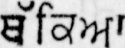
ਥੱਕਿਆ
